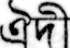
ঐদী
